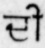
ਦੀ
